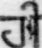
ਹੀ
